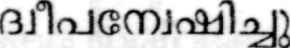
ദ്വീപന്വേഷിച്ചു
